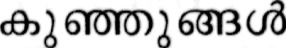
കുഞ്ഞുങ്ങള്‍
